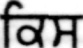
ਕਿਸ
